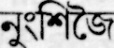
নুংশিজৈ
